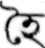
হৈ
